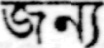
জন্য
